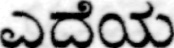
ಎದೆಯ
